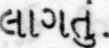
લાગતું.
